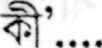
কী’....
